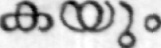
കയും
